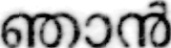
ഞാന്‍
